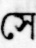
সে
